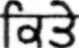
ਕਿਤੇ
